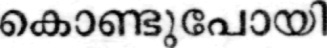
കൊണ്ടുപോയി
